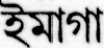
ইমাগা
